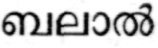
ബലാല്‍
